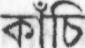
কাঁচি
